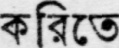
করিতে
